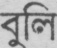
বুলি
